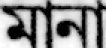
মানা
